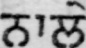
ਨਾਲੇ
